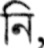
নি,
